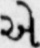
એ
